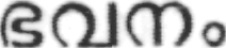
ഭവനം
